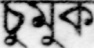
চুমুক
